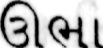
ઊભા
